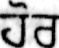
ਹੋਰ
